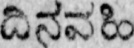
ದಿನವಹಿ
